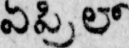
ಏಪ್ರಿಲ್
